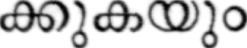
ക്കുകയും
